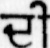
ਦੀ
